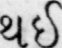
થઈ
